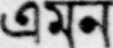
এমন
